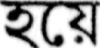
হয়ে
